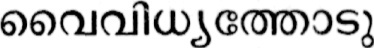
വൈവിധ്യത്തോടു
